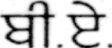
ਬੀ.ਏ.
